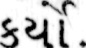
કર્યો.
